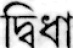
দ্বিধা
